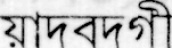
য়াদবদগী
